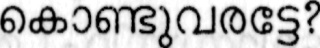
കൊണ്ടുവരട്ടേ?
